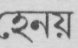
হেনয়
